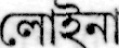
লোইনা
